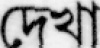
দেখা
